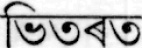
ভিতৰত
